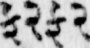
ફરફર
